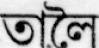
তালৈ
